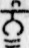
ਨੂੰ
